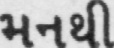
મનથી
